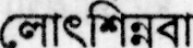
লোৎশি্ন্নবা
